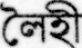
লৈহী
